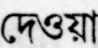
দেওয়া
